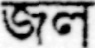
জল
